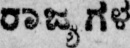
ರಾಜ್ಯಗಳ
